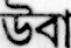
উবা
